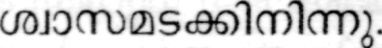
ശ്വാസമടക്കിനിന്നു.
